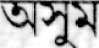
অসুম
